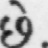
છે.
